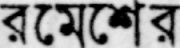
রমেশের
